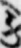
કે
